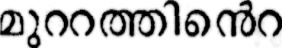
മുററത്തിന്റെ
